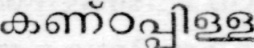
കണ്ഠപ്പിള്ള
